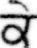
ਕੇ
